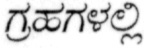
ಗ್ರಹಗಳಲ್ಲಿ
